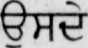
ਉਸਦੇ
